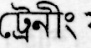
ট্রেনীং
